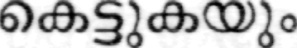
കെട്ടുകയും
